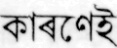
কাৰণেই
